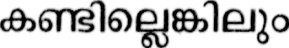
കണ്ടില്ലെങ്കിലും
